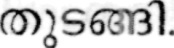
തുടങ്ങി.
